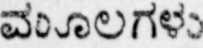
ಮೂಲಗಳು
